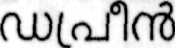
ഡപ്രീന്‍
